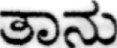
ತಾನು
